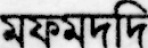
মফমদদি
